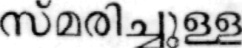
സ്മരിച്ചുള്ള
